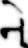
ને
